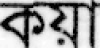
কয়া
